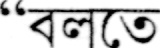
“বলতে
